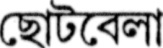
ছোটবেলা
